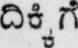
ದಿಕ್ಕಿಗೆ
